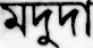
মদুদা
